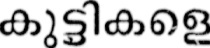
കുട്ടികളെ
